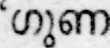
'ഗുണ
